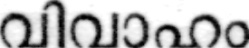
വിവാഹം
